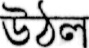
উঠল
